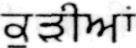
ਕੁੜੀਆਂ
